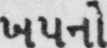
ખપનો
